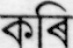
কৰি
